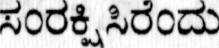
ಸಂರಕ್ಷಿಸಿರೆಂದು
